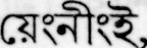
য়েংনীংই,
